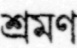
শ্রমণ
